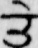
ਤੇ
